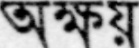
অক্ষয়
